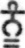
ਨੂੰ
